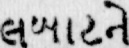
લબાટને
